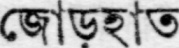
জোড়হাত
